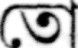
তো
